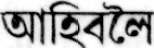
আহিবলৈ
